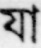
যা
